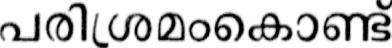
പരിശ്രമംകൊണ്ട്
